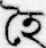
হৈ
